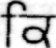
ਕਿ
